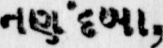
નણંદબા,
